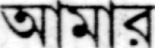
আমার
